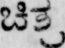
ಚಿತ್ರ
